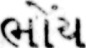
ભોંય
